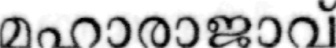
മഹാരാജാവ്
